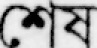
শেষ
